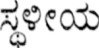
ಸ್ಥಳೀಯ
